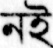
নই
